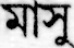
মাসু
